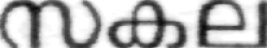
സകല
